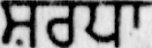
ਸ਼ਰਧਾ
